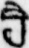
ਹੈ
